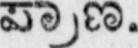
ಪ್ರಾಣ.
